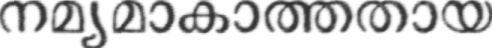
നമ്യമാകാത്തതായ
